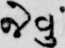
જેવું
